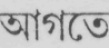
আগতে
